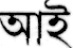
আই
